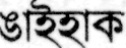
ঙাইহাক
